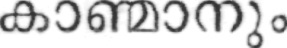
കാണ്മാനും
